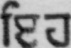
ਇਹ
